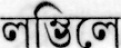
লম্ভিলে
